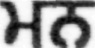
ਮਨ
